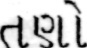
તણો
